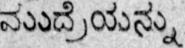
ಮುದ್ರೆಯನ್ನು
